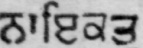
ਨਾਇਕਤ
